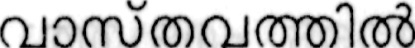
വാസ്തവത്തില്‍
